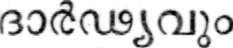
ദാര്‍ഢ്യവും
